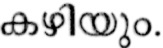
കഴിയും.
